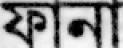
ফানা
